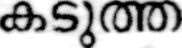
കടുത്ത
